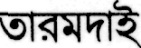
তারমদাই
